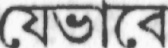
যেভাবে
